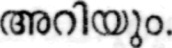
അറിയും.
